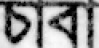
চাবা
